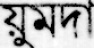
য়ুমদা
